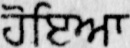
ਹੋਇਆ
